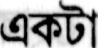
একটা
